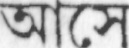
আসে
